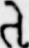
તે
